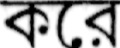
করে
